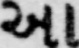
આ
